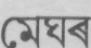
মেঘৰ
